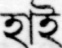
হাই
